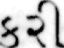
કરી
